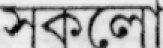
সকলো
